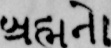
બ્રહ્મનો
